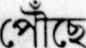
পৌঁছে
